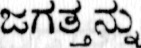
ಜಗತ್ತನ್ನು
